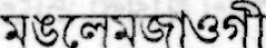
মঙলেমজাওগী
